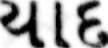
યાદ
